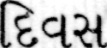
દિવસ
